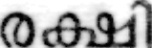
രക്ഷി
